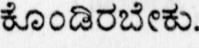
ಕೊಂಡಿರಬೇಕು.
